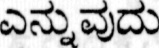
ಎನ್ನುವುದು
